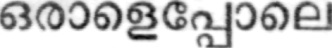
ഒരാളെപ്പോലെ
